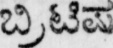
ಬ್ರಿಟಿಷ
